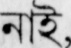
নাই,
